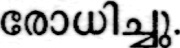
രോധിച്ചു.
